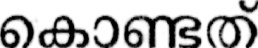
കൊണ്ടത്
